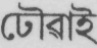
ঢৌৱাই
